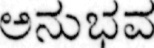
ಅನುಭವ
